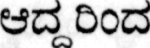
ಆದ್ದರಿಂದ
